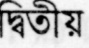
দ্বিতীয়
